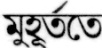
মুহূর্ততে
